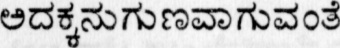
ಅದಕ್ಕನುಗುಣವಾಗುವಂತೆ
